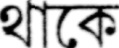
থাকে
